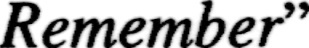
Remember"
